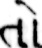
તો
